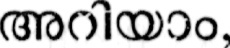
അറിയാം,
